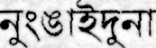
নুংঙাইদুনা
